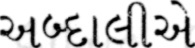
અબ્દાલીએ
